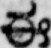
ಈ
